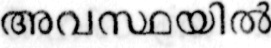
അവസ്ഥയില്‍
